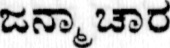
ಜನ್ಮಾಚಾರ
